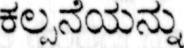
ಕಲ್ಪನೆಯನ್ನು
